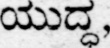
ಯುದ್ಧ,
